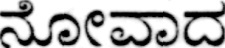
ನೋವಾದ
